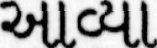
આવ્યા
